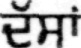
ਦੱਸਾਂ
